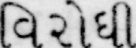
વિરોધી
